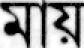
মায়
